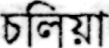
চলিয়া
